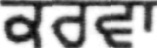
ਕਰਵਾ
